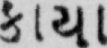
કાયા
